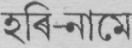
হৰি-নামে
